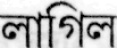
লাগিল
